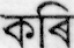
কৰি
